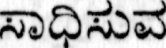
ಸಾಧಿಸುವ
